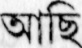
আছি
